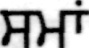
ਸਮਾਂ
